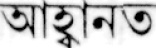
আহ্বানত
